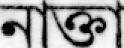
নাক্তা
